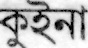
কুইনা
